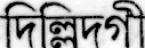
দিল্লিদগী
